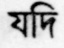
যদি
